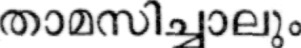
താമസിച്ചാലും
